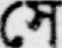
সে
